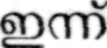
ഇന്ന്
